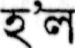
হ'ল
